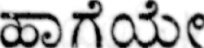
ಹಾಗೆಯೇ
